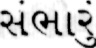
સંભારું
